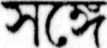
সঙ্গে
